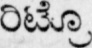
ರಿಟ್ರೊ
